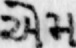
એમ
